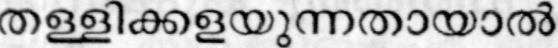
തള്ളിക്കളയുന്നതായാല്‍
